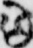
છે
